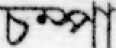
চম্পা
